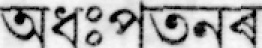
অধঃপতনৰ
